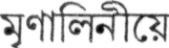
মৃণালিনীয়ে
